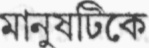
মানুষটিকে
